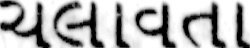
ચલાવતા
